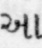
આ
